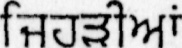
ਜਿਹੜੀਆਂ
